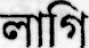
লাগি
